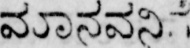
ಮಾನವನಿಗೆ
